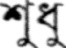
শুধু
